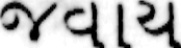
જવાય
